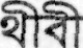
থীবী
